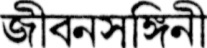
জীবনসঙ্গিনী
